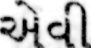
એવી
